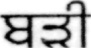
ਬੜੀ
